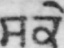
ਸਕੇ
